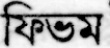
ফিভম
